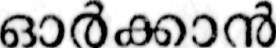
ഓര്‍ക്കാന്‍
